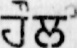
ਹੌਲ
